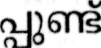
പ്പുണ്ട്
